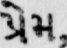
પ્રેમ,
